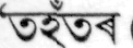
'তহঁতৰ
